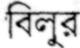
বিলুর
